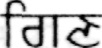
ਗਿਣ
